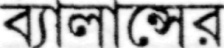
ব্যালান্সের
